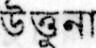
উত্তুনা
